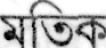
মতিক
